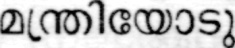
മന്ത്രിയോടു
